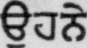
ਉਹਨੇ
